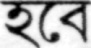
হবে
